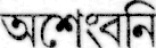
অশেংবনি
